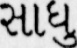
સાધુ
